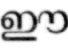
ഈ
